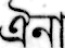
ঐনা
